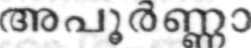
അപൂര്‍ണ്ണാ
